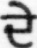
ਦੇ
